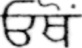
ਓਥੋਂ
